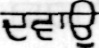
ਦਵਾਉ
